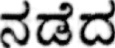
ನಡೆದ
